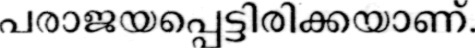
പരാജയപ്പെട്ടിരിക്കയാണ്.
